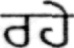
ਰਹੇ
